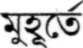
মুহূর্তে
